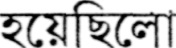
হয়েছিলো
